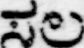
ಸಲ
